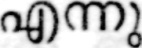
എന്നു
